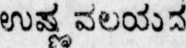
ಉಷ್ಣವಲಯದ
